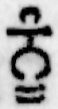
ਨੂੰ
